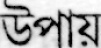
উপায়
